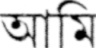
আমি
